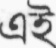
এই
